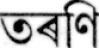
তৰণি
